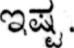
ಇಷ್ಟ.
